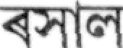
ৰসাল
